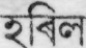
হৰিল
